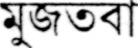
মুজতবা
